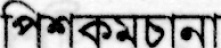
পিশকমচানা
